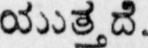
ಯುತ್ತದೆ.
